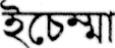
ইচেম্মা
